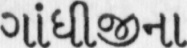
ગાંધીજીના
